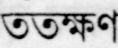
ততক্ষণ
